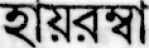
হায়রম্বা
